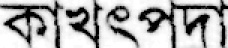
কাখৎপদা
